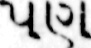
પણ
